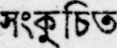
সংকুচিত
